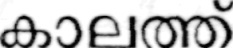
കാലത്ത്
